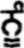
ਨੂੰ
